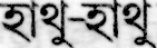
হাথু-হাথু
